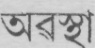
অৱস্থা
